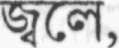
জ্বলে,
